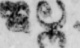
ಇಲ್ಲ.
